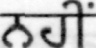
ਨਹੀਂ
